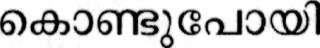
കൊണ്ടുപോയി
